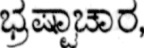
ಭ್ರಷ್ಟಾಚಾರ,
